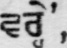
ਵਰ੍ਹੇ',
